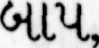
બાપ,
